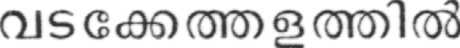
വടക്കേത്തളത്തില്‍
